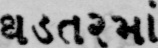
ઘડતરમાં
